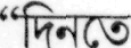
"দিনতে
